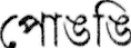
পোঙঙি
